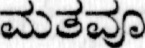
ಮತವೂ
